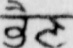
ਭੈਣ
